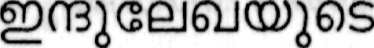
ഇന്ദുലേഖയുടെ
